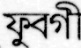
ফুবগী
